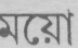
ময়ো
